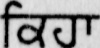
ਕਿਹਾ
